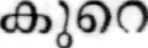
കുറെ
